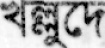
খল্লুদে
